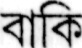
বাকি
